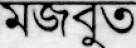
মজবুত
